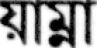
য়াম্না
